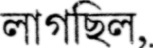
লাগছিল,
